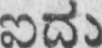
ಐದು
